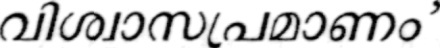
വിശ്വാസപ്രമാണം'
